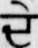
ਦੇ
